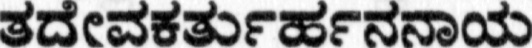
ತದೇವಕರ್ತುರ್ಹನನಾಯ
